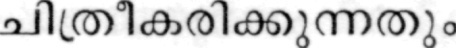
ചിത്രീകരിക്കുന്നതും
